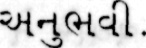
અનુભવી.
